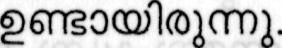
ഉണ്ടായിരുന്നു.
